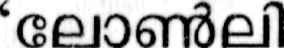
‘ലോണ്‍ലി
